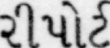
રીપોર્ટ
